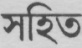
সহিত
